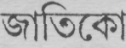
জাতিকো
